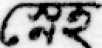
স্নেহ
